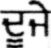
ਦੂਜੇ
